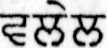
ਵਲੇਲ
